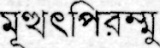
মূত্থৎপিরম্মু
